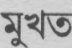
মুখত
